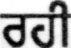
ਰਹੀ
